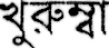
খুরুম্বা
